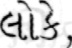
લોકે,
